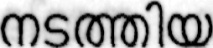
നടത്തിയ
